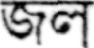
জল
